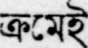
ক্রমেই
